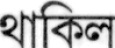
থাকিল
